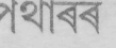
পথাৰৰ
